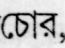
চোর,
